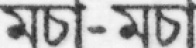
মচা-মচা
